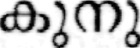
കുനു
